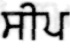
ਸੀਪ
